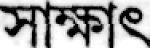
সাক্ষাৎ
